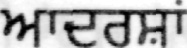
ਆਦਰਸ਼ਾਂ
